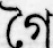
গৈ
